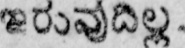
ಇರುವುದಿಲ್ಲ.
